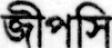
জীপসি
